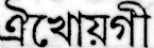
ঐখোয়গী
